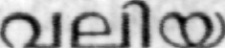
വലിയ
